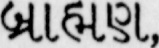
બ્રાહ્મણ,
